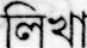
লিখা
